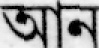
আন
